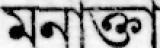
মনাক্তা
